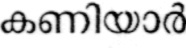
കണിയാര്‍
